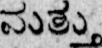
ಮತ್ತು
